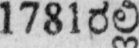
1781ರಲ್ಲಿ
